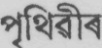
পৃথিৱীৰ
